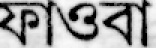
ফাওবা
